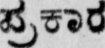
ಪ್ರಕಾರ
